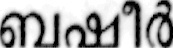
ബഷീര്‍
